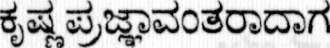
ಕೃಷ್ಣಪ್ರಜ್ಞಾವಂತರಾದಾಗ
